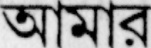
আমার
